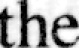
the
